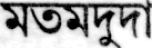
মতমদুদা
